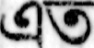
এত
